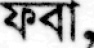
ফবা,
